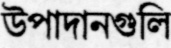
উপাদানগুলি
